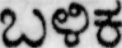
ಬಳಿಕ
